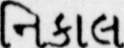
નિકાલ
